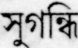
সুগন্ধি
